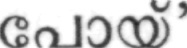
പോയ്'
